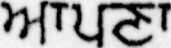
ਆਪਣਾ
